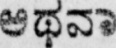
ಅಥವಾ
